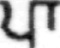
ਪਾ
